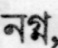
নগ্ন,
